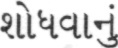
શોધવાનું
